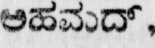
ಅಹಮದ್,
